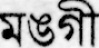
মঙগী
